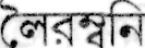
লৈরম্বনি
